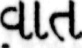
વાત
